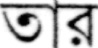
তার
